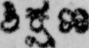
ಶಿಕ್ಷಣ
